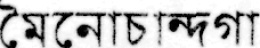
মৈনোচান্দগা
